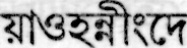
য়াওহন্নীংদ
